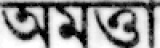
অমত্তা
